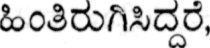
ಹಿಂತಿರುಗಿಸಿದ್ದರೆ,
